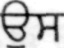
ਉਸ
